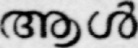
ആള്‍
